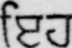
ਇਹ
